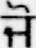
ਜੋ
